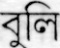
বুলি
